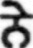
ਨੇ
